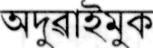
অদুৱাইমুক
